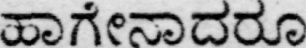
ಹಾಗೇನಾದರೂ
